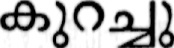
കുറച്ചു
